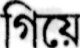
গিয়ে
